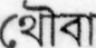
থৌবা
